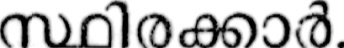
സ്ഥിരക്കാര്‍.
